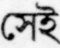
সেই
